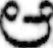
ಆ
